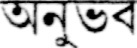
অনুভব
